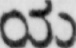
ಯ
